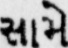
સામે
